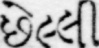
છેલ્લી
